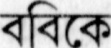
ববিকে
